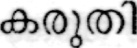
കരുതി
